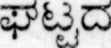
ಘಟ್ಟದ
